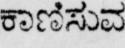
ಕಾಣಿಸುವ
